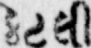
કેટલી
